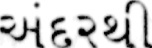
અંદરથી
